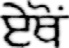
ਏਥੋਂ
